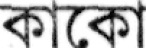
কাকো
